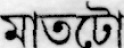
মাতটো
